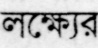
লক্ষ্যের
